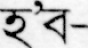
হ'ব-
